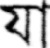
যা
